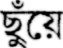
ছুঁয়ে
